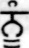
ਨੂੰ
